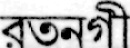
রতনগী
